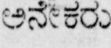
ಅನೇಕರು
